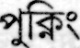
পুক্নিং
